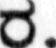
ರ.
